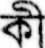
কী
